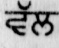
ਵੱਲ
